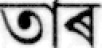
তাৰ
